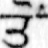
ਤੋਂ
